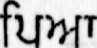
ਪਿਆ
